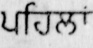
ਪਹਿਲਾਂ
